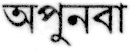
অপুনবা
